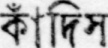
কাঁদিস
